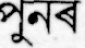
পুনৰ
